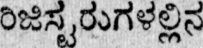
ರಿಜಿಸ್ಟರುಗಳಲ್ಲಿನ
